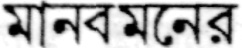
মানবমনের
